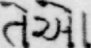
તેઓ
